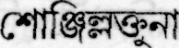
শোঞ্জিল্লক্তুনা
